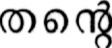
തന്റെ
